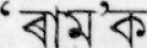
'ৰাম'ক
